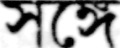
সঙ্গে
